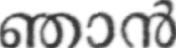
ഞാന്‍
